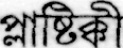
প্লাষ্টিক্কী
